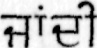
ਜਾਂਦੀ
